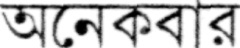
অনেকবার
